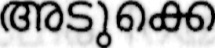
അടുക്കെ
